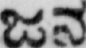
ಜನ
